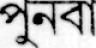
পুনবা
